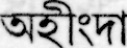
অহীংদা
